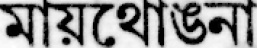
মায়থোঙনা
